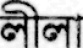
লীলা
